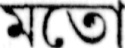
মতো
